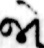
જો
